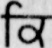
ਕਿ
